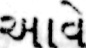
આવે
